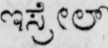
ಇಸ್ರೇಲ್
